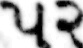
પર
